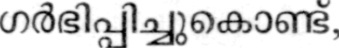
ഗര്‍ഭിപ്പിച്ചുകൊണ്ട്,
